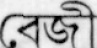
বেজী
